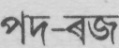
পদ-ৰজ
